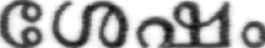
ശേഷം
